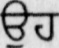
ਉਹ
